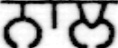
ਨਾਲ
